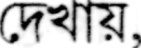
দেখায়,
